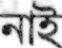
নাই
